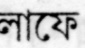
লাফে
